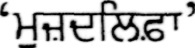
'ਮੁਜ਼ਦਲਿਫ਼ਾ'
